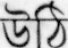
উঠি
